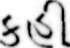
કહી
